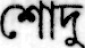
শোদু
